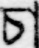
চা
